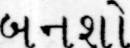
બનશો
